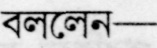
বললেন–
